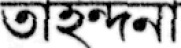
তাহন্দনা
